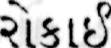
રોકાઈ
